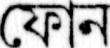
ফোন
